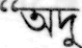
“অদু
